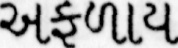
અફળાય
